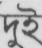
দুই
